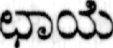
ಛಾಯೆ
